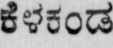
ಕೆಳಕಂಡ
